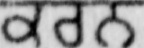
ਕਰਨ
